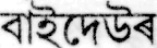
বাইদেউৰ
